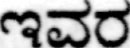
ಇವರ
